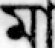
মা
